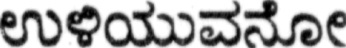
ಉಳಿಯುವನೋ
